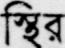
স্থির
